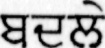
ਬਦਲੇ
